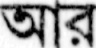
আর
